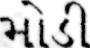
મોડી
